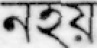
নহয়
